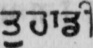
ਤੁਹਾਡੀ
